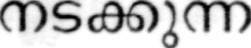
നടക്കുന്ന
